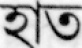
হাত
